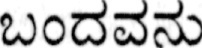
ಬಂದವನು
